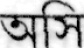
অসি
